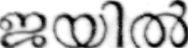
ജയില്‍
